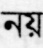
নয়
